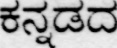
ಕನ್ನಡದ
